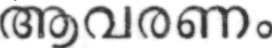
ആവരണം
